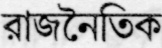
রাজনৈতিক
